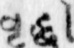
વૃદ્ધી
